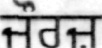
ਜੌਰਜ਼
